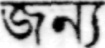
জন্য
